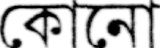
কোনো
